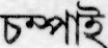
চম্পাই
